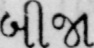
બીજા
